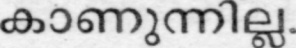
കാണുന്നില്ല.
